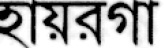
হায়রগা
